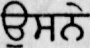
ਉਸਨੇ
